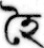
হৈ
